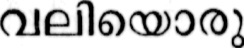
വലിയൊരു
